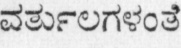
ವರ್ತುಲಗಳಂತೆ
